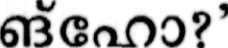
ങ്ഹോ?’
